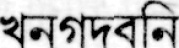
খমগদবনি
